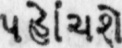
પહોંચશે
